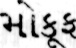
મોકૂફ
